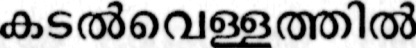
കടല്‍വെള്ളത്തില്‍
